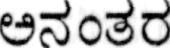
ಅನಂತರ
